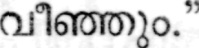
വീഞ്ഞും.”
